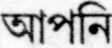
আপনি
